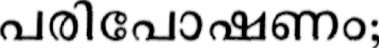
പരിപോഷണം;
